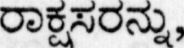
ರಾಕ್ಷಸರನ್ನು,
